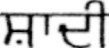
ਸ਼ਾਦੀ
